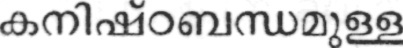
കനിഷ്ഠബന്ധമുള്ള
